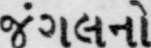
જંગલનો
